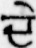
ਦੇ
